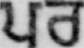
ਪਰ
